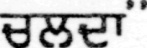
ਚਲਦਾ''
